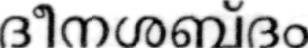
ദീനശബ്ദം
